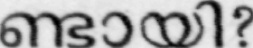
ണ്ടായി?
